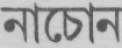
নাচোন
